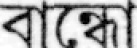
বান্ধো
